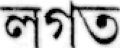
লগত
